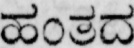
ಹಂತದ
